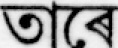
তাৰে
